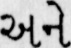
અને
